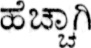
ಹೆಚ್ಚಾಗಿ
